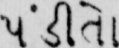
પંડીતો
